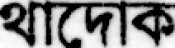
থাদোক
